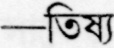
–তিষ্য
